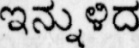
ಇನ್ನುಳಿದ
